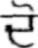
ਦੋ
